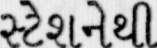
સ્ટેશનેથી
